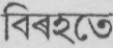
বিৰহতে
